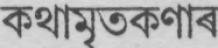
কথামৃতকণাৰ
